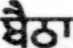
ਬੈਠਾ
